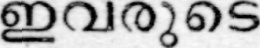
ഇവരുടെ
